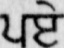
ਪਏ
